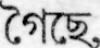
গৈছে,
